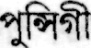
পুন্সিগী
